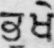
ਭੁਖੇ
